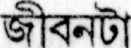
জীবনটা
